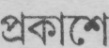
প্ৰকাশে
